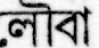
লৌবা
